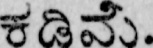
ಕಡಿಮೆ.
